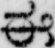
ಈ
